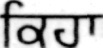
ਕਿਹਾ
